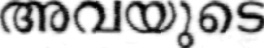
അവയുടെ
